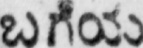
ಬಗೆಯ
